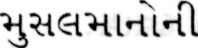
મુસલમાનોની
